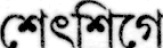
শেৎশিগে
